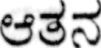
ಆತನ
